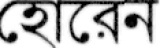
হোরেন
